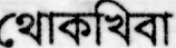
থোকখিবা
